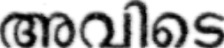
അവിടെ
